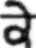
ਕੇ
